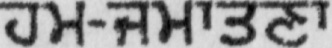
ਹਮ-ਜਮਾਤਣਾ
